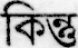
কিন্তু
